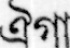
ঐগা
